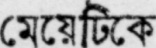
মেয়েটিকে
